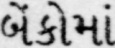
બેંકોમાં
